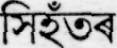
সিহঁতৰ
